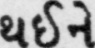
થઈને
